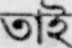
তাই
